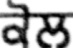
ਕੋਲ
